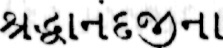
શ્રદ્ધાનંદજીના
